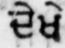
ਦੇਖੇ
